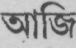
আজি
